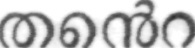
തന്റെ
